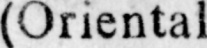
(Otiental
